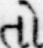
તો
